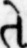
તે
